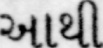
આથી
